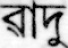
ৱাদু
